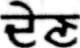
ਦੇਣ
